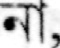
না,
